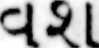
વશ
